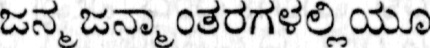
ಜನ್ಮಜನ್ಮಾಂತರಗಳಲ್ಲಿಯೂ
